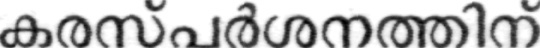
കരസ്പര്‍ശനത്തിന്
